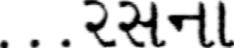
...રસના
